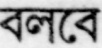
বলবে
